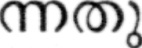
ന്നതു
